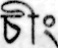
চীং
